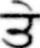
ਤੇ
